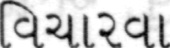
વિચારવા
